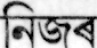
নিজৰ
